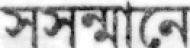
সসন্মানে
